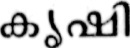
കൃഷി
